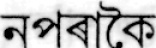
নপৰাকৈ
